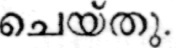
ചെയ്തു.
